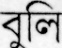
বুলি
